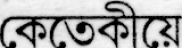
কেতেকীয়ে
